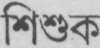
শিশুক
